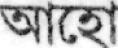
আহো
